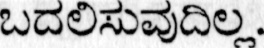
ಬದಲಿಸುವುದಿಲ್ಲ.
